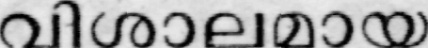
വിശാലമായ
